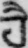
ਹੈ
